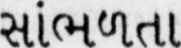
સાંભળતા
